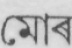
মোৰ
